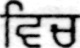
ਵਿਚ
